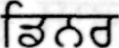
ਡਿਨਰ
